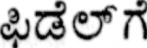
ಫಿಡೆಲ್ಗೆ
